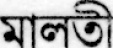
মালতী
